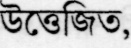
উত্তেজিত,
